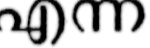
എന്ന
